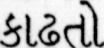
કાઢતો
